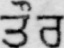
ਤੌਰ
